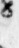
કે
